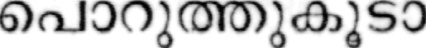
പൊറുത്തുകൂടാ
